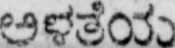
ಅಳತೆಯ
